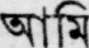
আমি
